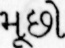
મૂછો
